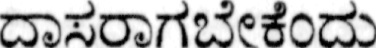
ದಾಸರಾಗಬೇಕೆಂದು
